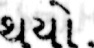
થયો.
